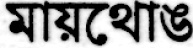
মায়থোঙ
